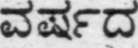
ವರ್ಷದ
